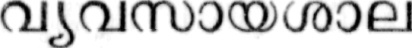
വ്യവസായശാല
